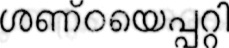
ശണ്ഠയെപ്പറ്റി
